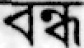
বন্ধ
